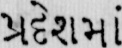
પ્રદેશમાં
